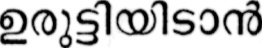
ഉരുട്ടിയിടാന്‍
